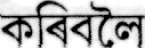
কৰিবলৈ
